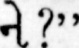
ને?"
